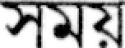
সময়
